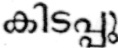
കിടപ്പു
